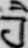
ਹੈ
